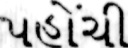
પહોંચી
